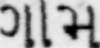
ગામ
